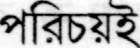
পরিচয়ই
